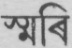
স্মৰি
